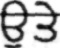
ਉਤੇ
